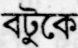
বটুকে
